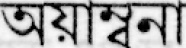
অয়াম্বনা
